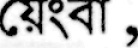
য়েংবা,
